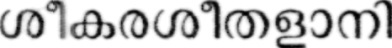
ശീകരശീതളാനി
